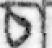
চা
